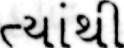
ત્યાંથી
